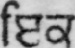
ਇਕ
